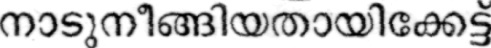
നാടുനീങ്ങിയതായിക്കേട്ട്
